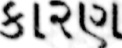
કારણ
